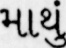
માથું
